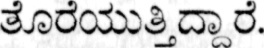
ತೊರೆಯುತ್ತಿದ್ದಾರೆ.
